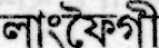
লাংফৈগী
